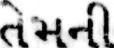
તેમની
